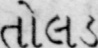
તોલડ
